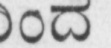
ರಿಂದ
